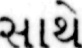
સાથે
